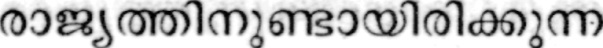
രാജ്യത്തിനുണ്ടായിരിക്കുന്ന
